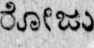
ರೋಜು
